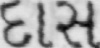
દાસ
